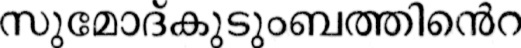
സുമോദ്കുടുംബത്തിന്റെ
